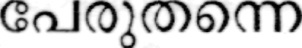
പേരുതന്നെ
